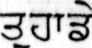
ਤੁਹਾਡੇ
